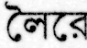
লৈরে
